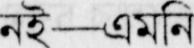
নই-এমনি
